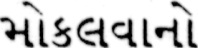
મોકલવાનો
